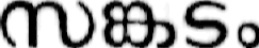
സങ്കടം
